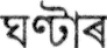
ঘণ্টাৰ
